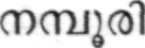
നമ്പൂരി
